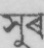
সুৰ
